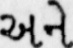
અને
